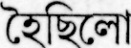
হৈছিলো
